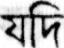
যদি
